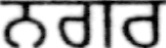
ਨਗਰ
